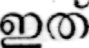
ഇത്
